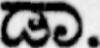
ಡಾ.
